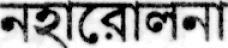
নহারোলনা
